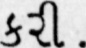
કરી.
